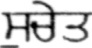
ਸੁਚੇਤ
